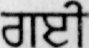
ਗਈ
